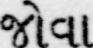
જોવા
